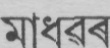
মাধৱৰ
